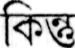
কিন্তু
